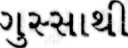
ગુસ્સાથી
